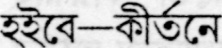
হইবে—কীর্তনে
